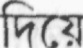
দিয়ে
